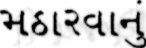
મઠારવાનું
